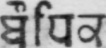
ਬੌਧਿਕ
